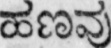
ಹಣವು
